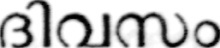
ദിവസം
